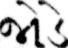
જોડે
